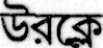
উরক্লে
